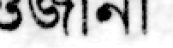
ওজানা
